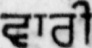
ਵਾਰੀ
